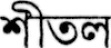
শীতল
